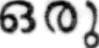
ഒരു
